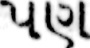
પણ
